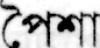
পৈশা
